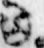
છે.
